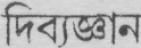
দিব্যজ্ঞান
